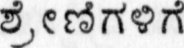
ಶ್ರೇಣಿಗಳಿಗೆ
